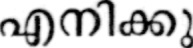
എനിക്കു
